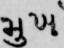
મુર્ખ
